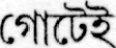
গোটেই
